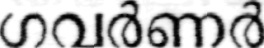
ഗവര്‍ണര്‍
